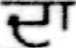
ਦਾ
